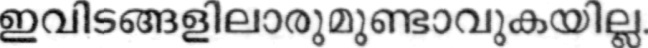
ഇവിടങ്ങളിലാരുമുണ്ടാവുകയില്ല.
